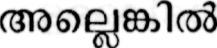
അല്ലെങ്കില്‍
